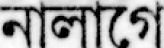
নালাগে
